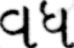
વધ
